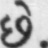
છે.
